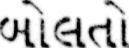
બોલતો
